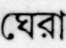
ঘেরা
